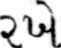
રખે
